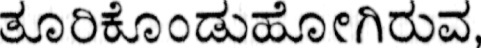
ತೂರಿಕೊಂಡುಹೋಗಿರುವ,
